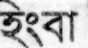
হিংবা
